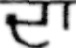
ਦਾ
